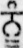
ਨੂੰ
